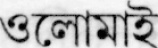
ওলোমাই
